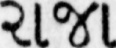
રાજા
